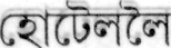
হোটেললৈ
